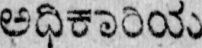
ಅಧಿಕಾರಿಯ
